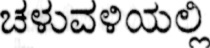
ಚಳುವಳಿಯಲ್ಲಿ
